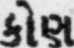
કોણ
